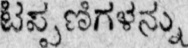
ಟಿಪ್ಪಣಿಗಳನ್ನು
